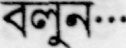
বলুন...
